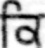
ਕਿ
